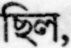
ছিল,
